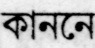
কাননে
